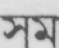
সম
